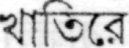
খাতিরে
